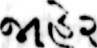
જાહેર
